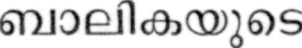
ബാലികയുടെ
